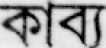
কাব্য
